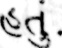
હતું.
